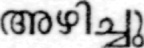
അഴിച്ചു
